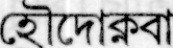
হৌদোক্নবা
